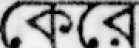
কেরে
